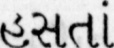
હસતાં
